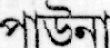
পাউনা
